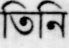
তিনি
